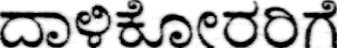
ದಾಳಿಕೋರರಿಗೆ
